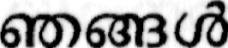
ഞങ്ങള്‍
